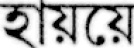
হায়য়ে
